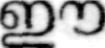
ഈ
